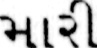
મારી
